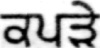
ਕਪੜੇ
